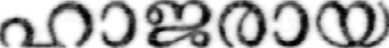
ഹാജരായ
